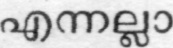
എന്നല്ലാ
